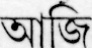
আজি
